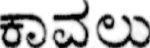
ಕಾವಲು
